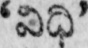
‘ವಿಧಿ’
